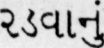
રડવાનું
